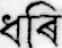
ধৰি
